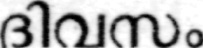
ദിവസം
